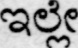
ಇಲ್ಲೇ
